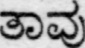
ತಾವು
